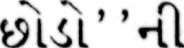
છોડો"ની
